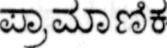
ಪ್ರಾಮಾಣಿಕ
